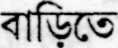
বাড়িতে
